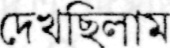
দেখছিলাম
